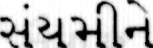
સંયમીને
